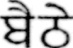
ਬੈਠੇ
